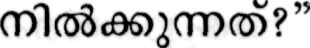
നില്‍ക്കുന്നത്?”
